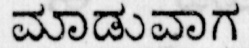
ಮಾಡುವಾಗ
